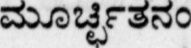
ಮೂರ್ಚ್ಛಿತನಂ
